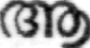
ആ
